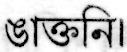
ঙাক্তনি।
